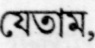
যেতাম,
